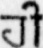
ਹੀ
